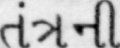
તંત્રની
